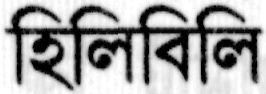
হিলিবিলি
